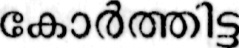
കോര്‍ത്തിട്ട
